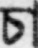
চা
